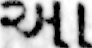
આ
